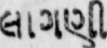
લાગણી
